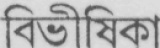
বিভীষিকা
